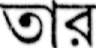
তার
